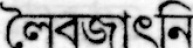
লৈবজাৎনি
